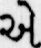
એ
